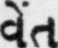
વેંત
